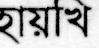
হায়খি
